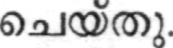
ചെയ്തു.
